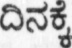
ದಿನಕ್ಕೆ
